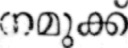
നമുക്ക്
